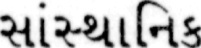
સાંસ્થાનિક
